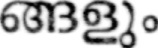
ങ്ങളും
